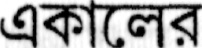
একালের
